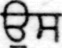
ਉਸ
